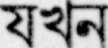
যখন
